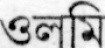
ওলমি
